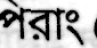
পিরাং
